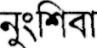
নুংশিবা
